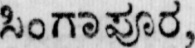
ಸಿಂಗಾಪೂರ,
